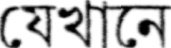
যেখানে
